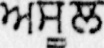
ਅਸੂਲ
